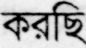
করছি
